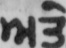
ਅਤੇ
